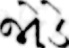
જોડે
